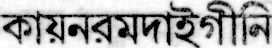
কায়নরমদাইগীনি
